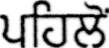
ਪਹਿਲੋਂ
